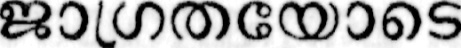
ജാഗ്രതയോടെ
